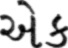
એક
